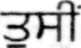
ਤੁਸੀਂ
